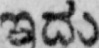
ಇದು
